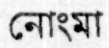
নোংমা
